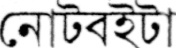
নোটবইটা
